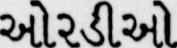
ઓરડીઓ
